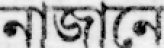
নাজানে
